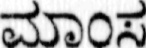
ಮಾಂಸ
